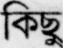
কিছু
